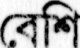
বেশি
